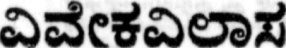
ವಿವೇಕವಿಲಾಸ
